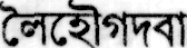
লৈহৌদগবা
